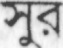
সুর
